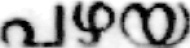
പഴയ
